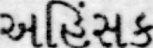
અહિંસક
